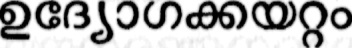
ഉദ്യോഗക്കയറ്റം
